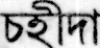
চহীদা
